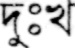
দুঃখ
